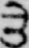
ਤੇ
